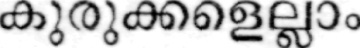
കുരുക്കളെല്ലാം
